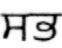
ਸਭ
